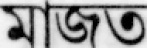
মাজত
